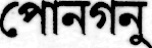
পোনগনু
